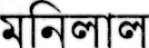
মনিলাল
